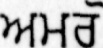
ਅਮਰੋ
